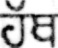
ਹੱਥ
